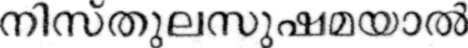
നിസ്തുലസുഷമയാല്‍
